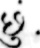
છું.
